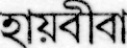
হায়বীবা
